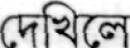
দেখিলে
